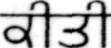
ਕੀਤੀ
